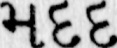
મદદ
